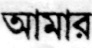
আমার
